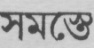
সমস্তে
